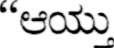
"ಆಯ್ತು
